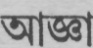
আজ্ঞা
